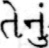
તેનું
